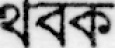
থবক
